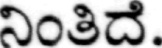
ನಿಂತಿದೆ.
